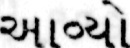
આવ્યો
